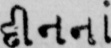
દીનનાં
